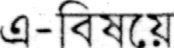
এ-বিষয়ে
